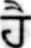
ਹੈ
